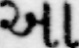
આ
